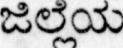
ಜಿಲ್ಲೆಯ
